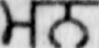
ਮਨ
